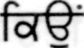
ਕਿਉਂ
